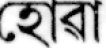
হোৱা
